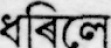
ধৰিলে
